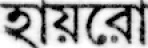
হায়রো
